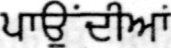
ਪਾਉਂਦੀਆਂ
